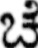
ಚೆ
